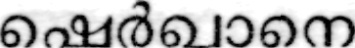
ഷെര്‍ഖാമ്മെ
